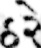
ઠરે
